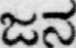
ಜನ
